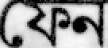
ফেন
